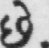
છે.
